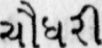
ચૌધરી
